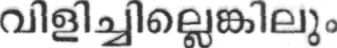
വിളിച്ചില്ലെങ്കിലും
